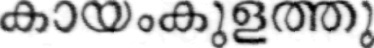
കായംകുളത്തു
